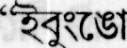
“ইবুংঙো
